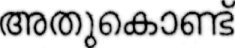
അതുകൊണ്ട്
